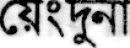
য়েংদুনা
